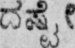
ದಷ್ಟೇ
